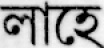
লাহে
